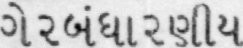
ગેરબંધારણીય
